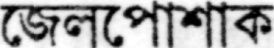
জেলপোশাক
